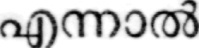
എന്നാല്‍
